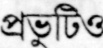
প্রভুটিও
